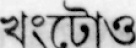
খংটোও
